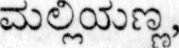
ಮಲ್ಲಿಯಣ್ಣ,
